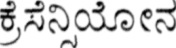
ಕ್ರೆಸೆನ್ಸಿಯೋನ
